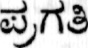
ಪ್ರಗತಿ
